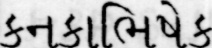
કનકાભિષેક
